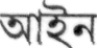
আইন
